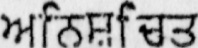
ਅਨਿਸ਼ਚਿਤ
